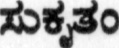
ಸುಕೃತ೦
